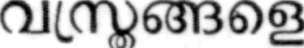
വസ്ത്രങ്ങളെ
